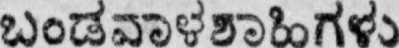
ಬಂಡವಾಳಶಾಹಿಗಳು
